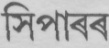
সিপাৰৰ
